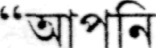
“আপনি
